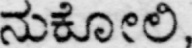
ನುಕೋಲಿ,
